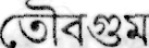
তৌবগুম
